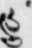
હું
